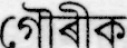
গৌৰীক
